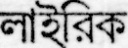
লাইরিক
